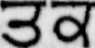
ਤਕ
